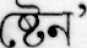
ষ্টেন'
